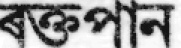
ৰক্তপান
